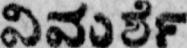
ವಿಮರ್ಶೆ
